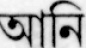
আনি
